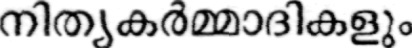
നിത്യകര്‍മ്മാദികളും
